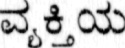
ವ್ಯಕ್ತಿಯ
